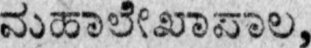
ಮಹಾಲೇಖಾಪಾಲ,
